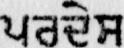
ਪਰਦੇਸ
